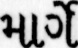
માર્ગે
